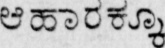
ಆಹಾರಕ್ಕೂ
